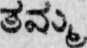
ತಮ್ಮ
